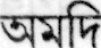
অমদি
